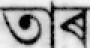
তাৰ
